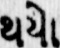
થયો
